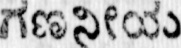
ಗಣನೀಯ
